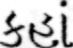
કહાં
